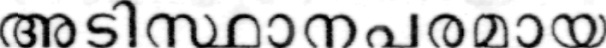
അടിസ്ഥാനപരമായ
